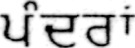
ਪੰਦਰਾਂ
